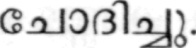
ചോദിച്ചു.
